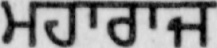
ਮਹਾਰਾਜ
